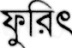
ফুরিৎ
